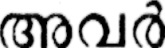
അവര്‍
